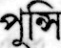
পুন্সি
